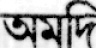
অমদি
